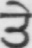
ਤੇ
